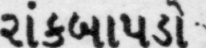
રાંકબાપડો
